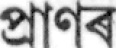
প্রাণৰ
